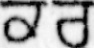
ਕਰ
